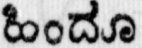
ಹಿಂದೂ
